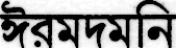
ঈরমদমনি
